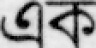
এক
